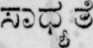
ಸಾಧ್ಯತೆ
